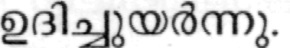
ഉദിച്ചുയര്‍ന്നു.
